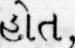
હોત,
